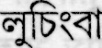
লুচিংবা
